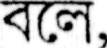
বলে,
